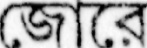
জোরে
